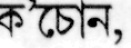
ক'চোন,
